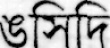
ঙসিদি
